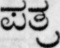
ಪತ್ರ
